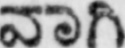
ವಾಗಿ
